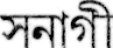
সনাগী
